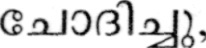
ചോദിച്ചു,
